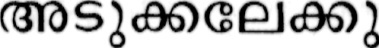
അടുക്കലേക്കു
